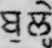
ਬੁਲ੍ਹੇ
